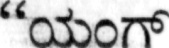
“ಯಂಗ್
